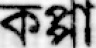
কপ্পা
